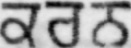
ਕਰਨ
